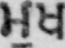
ਮੁਖ
